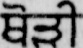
ਥੋੜੀ
